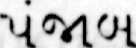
પંજાબ
